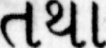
તથા
